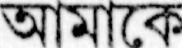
আমাকে
